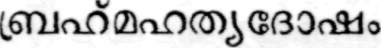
ബ്രഹ്മഹത്യദോഷം
